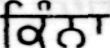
ਕਿੰਨਾ
